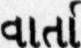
વાર્તા
